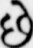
છે
